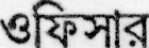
ওফিসার
